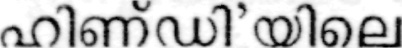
ഹിണ്‌ഡി'യിലെ
